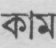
কাম
